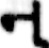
ન
